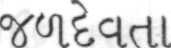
જળદેવતા
